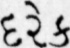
દરેક
